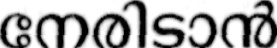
നേരിടാന്‍
